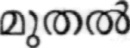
മുതല്‍
